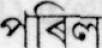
পৰিল
